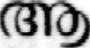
ആ
